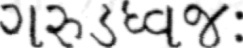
ગરુડધ્વજઃ
